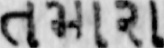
તમારા
